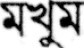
মখুম
